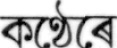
কণ্ঠেৰে
